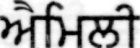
ਐਮਿਲੀ
